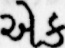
એક
